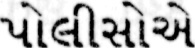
પોલીસોએ
